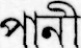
পানী
